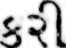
કરી
